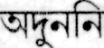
অদুননি
